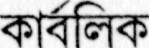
কার্বলিক
